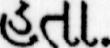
હતા.
